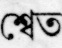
শ্বেত
